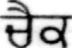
ਚੈਕ
